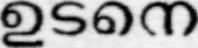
ഉടനെ
